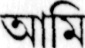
আমি
